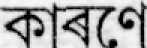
কাৰণে
